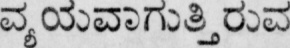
ವ್ಯಯವಾಗುತ್ತಿರುವ
